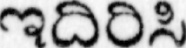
ಇದಿರಿಸಿ
